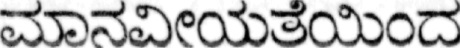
ಮಾನವೀಯತೆಯಿಂದ
